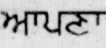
ਆਪਣਾ
